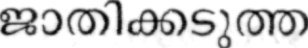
ജാതിക്കടുത്ത
